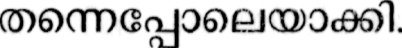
തന്നെപ്പോലെയാക്കി.
